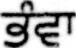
ਭੰਵਾ
